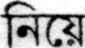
নিয়ে
